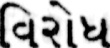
વિરોધ
